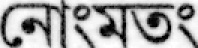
নোংমতং
